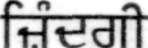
ਜ਼ਿੰਦਗੀ
